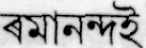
ৰমানন্দই
